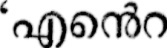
‘എന്റെ
